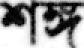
শঙ্গ
